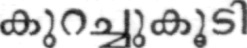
കുറച്ചുകൂടി
